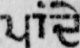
ਪਾਂਦੇ
